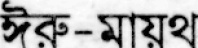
ঈরু-মায়থ
